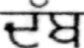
ਦੱਬ
